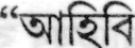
"আহিবি
